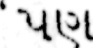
'પણ
